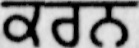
ਕਰਨ
